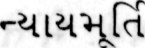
ન્યાયમૂર્તિ
